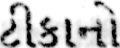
ટીકાનો
